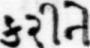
કરીને
